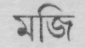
মজি
